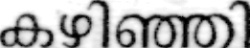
കഴിഞ്ഞി
